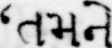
'તમને
